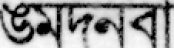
ঙমদনবা
